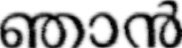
ഞാന്‍
